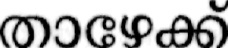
താഴേക്ക്
